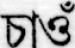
চাওঁ
